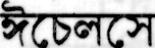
ঈচেলসে
